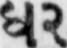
ઘર
